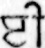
ਈ
